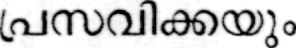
പ്രസവിക്കയും
